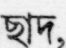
ছাদ,
